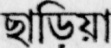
ছাড়িয়া
